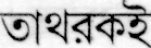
তাথরকই
